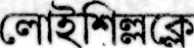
লোইশিল্লক্লে
